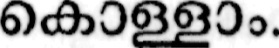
കൊള്ളാം.
